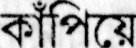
কাঁপিয়ে
